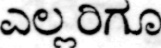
ಎಲ್ಲರಿಗೂ
